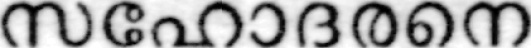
സഹോദരനെ
